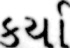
કર્યા
